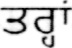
ਤਰ੍ਹਾ
